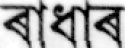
ৰাধাৰ
